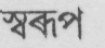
স্বৰূপ
